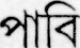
পাবি
